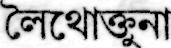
লৈথোক্তুনা
